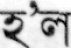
হ'ল
